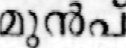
മുന്‍പ്
